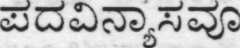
ಪದವಿನ್ಯಾಸವೂ
